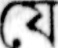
যে
